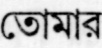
তোমার
